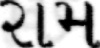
રામ
